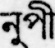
নুপী
